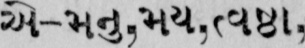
એ-મનુ,મય,ત્વષ્ઠા,
